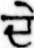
ਦੇ
